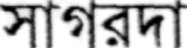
সাগরদা
